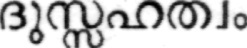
ദുസ്സഹത്വം
